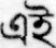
এই
